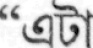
"এটা
